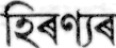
হিৰণ্যৰ
